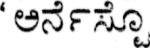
'ಅರ್ನೆಸ್ಟೊ
